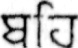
ਬਹਿ
